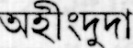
অহীংদুদা
